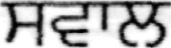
ਸਵਾਲ
